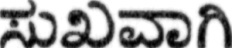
ಸುಖವಾಗಿ
